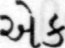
એક
